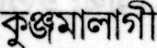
কুঞ্জমালাগী
